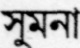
সুমনা
